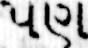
પણ
